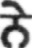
ਨੇ
